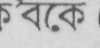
ক'বকে
